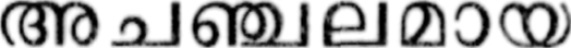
അചഞ്ചലമായ
